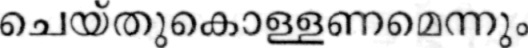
ചെയ്തുകൊള്ളണമെന്നും
